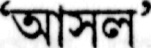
'আসল'
